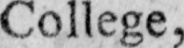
College,
